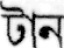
টান
